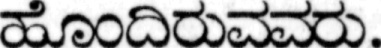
ಹೊಂದಿರುವವರು.
